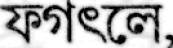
ফগৎলে,
